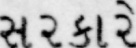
સરકારે
